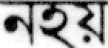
নহয়
